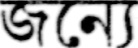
জন্যে
